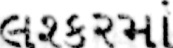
લશ્કરમાં
